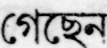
গেছেন
